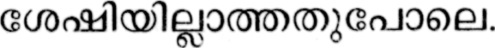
ശേഷിയില്ലാത്തതുപോലെ.
